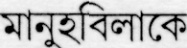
মানুহবিলাকে
